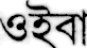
ওইবা
